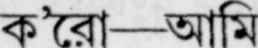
ক'রো-আমি
